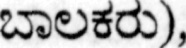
ಬಾಲಕರು),
